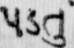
પડતું
